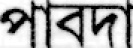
পাবদা
